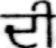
ਦੀ
